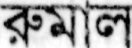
রুমাল
